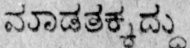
ಮಾಡತಕ್ಕದ್ದು
